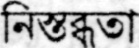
নিস্তব্ধতা
